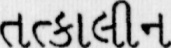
તત્કાલીન
